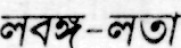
লবঙ্গ-লতা
